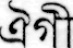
ঐগী
